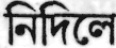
নিদিলে
